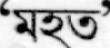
‘মহত’
